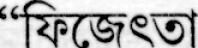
“ফিজেৎতা
